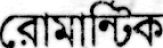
রোমান্টিক
